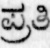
ಪ್ರತಿ
